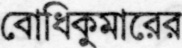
বোধিকুমারের
